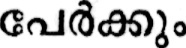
പേര്‍ക്കും
